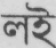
লই
